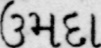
ઉમદા
